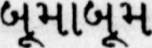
બૂમાબૂમ
